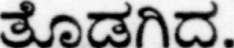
ತೊಡಗಿದ.
